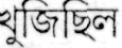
খুজিছিল
